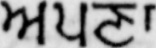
ਅਪਣਾ
